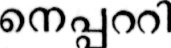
നെപ്പററി
